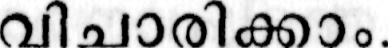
വിചാരിക്കാം.
